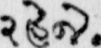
રહેજે.
